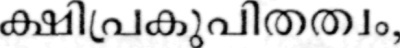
ക്ഷിപ്രകുപിതത്വം,
